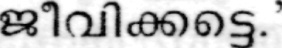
ജീവിക്കട്ടെ.’
